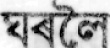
ঘৰলৈ
